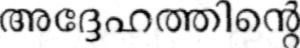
അദ്ദേഹത്തിന്റെ
